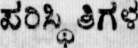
ಪರಿಸ್ಥಿತಿಗಳ
